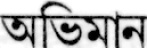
অভিমান
